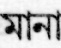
মানা
